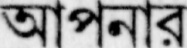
আপনার
